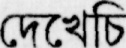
দেখেচি
